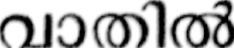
വാതില്‍
